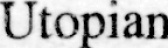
Utopian
